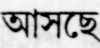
আসছে
